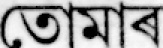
তোমাৰ
